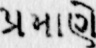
પ્રમાણે
